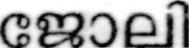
ജോലി
